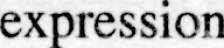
expression
